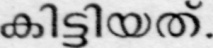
കിട്ടിയത്.
